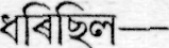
ধৰিছিল-
